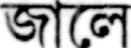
জালে
